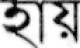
হায়
